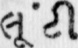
લૂંટી
